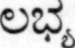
ಲಭ್ಯ
